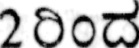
2ರಿಂದ
